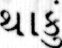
થાકું
